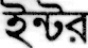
ইন্টর
